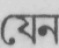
যেন
